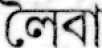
লৈবা
